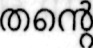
തന്റെ
